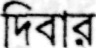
দিবার
